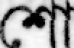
শো
